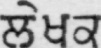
ਲੇਖਕ
